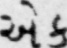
એક
